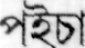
পইচা
